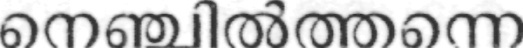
നെഞ്ചില്‍ത്തന്നെ
